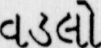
વડલો
